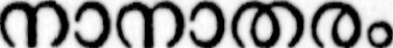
നാനാതരം
